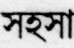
সহসা
